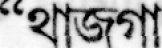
“থাজগা
